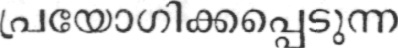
പ്രയോഗിക്കപ്പെടുന്ന
